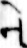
ને
